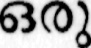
ഒരു
